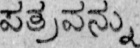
ಪತ್ರವನ್ನು
